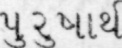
પુરુષાર્થ
